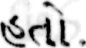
હતો.
